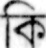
কি
